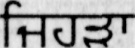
ਜਿਹੜਾ
